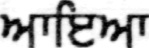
ਆਇਆ
